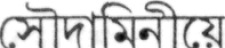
সৌদামিনীয়ে
